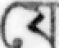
যে
